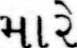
મારે
